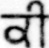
ਕੀ
